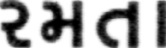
રમતા
